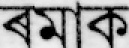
ৰমাক
